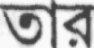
তার
